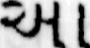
આ
